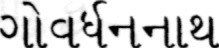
ગોવર્ધનનાથ
